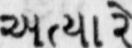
અત્યારે
